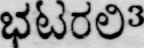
ಭಟರಲಿ3
